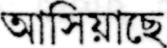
আসিয়াছে
